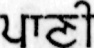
ਪਾਣੀ
